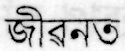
জীৱনত
